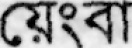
য়েংবা
